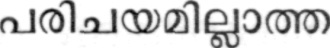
പരിചയമില്ലാത്ത
